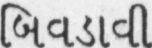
બિવડાવી
